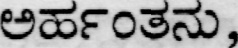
ಅರ್ಹಂತನು,
